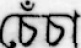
চেঁচা
